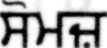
ਸੋਮਜ਼
